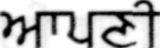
ਆਪਣੀ
